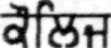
ਕੌਲਿਜ
